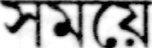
সময়ে
